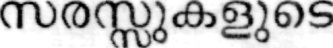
സരസ്സുകളുടെ
